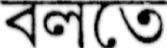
বলতে
